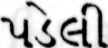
પડેલી
